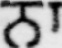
ਨਾ
